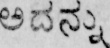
ಅದನ್ನು
